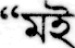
"মই
